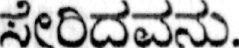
ಸೇರಿದವನು.
